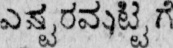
ಎಷ್ಟರಮಟ್ಟಿಗೆ
